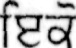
ਇਕੋ
